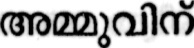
അമ്മുവിന്
